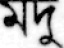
মদু
